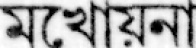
মখোয়না
